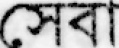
সেবা
